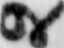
જ
